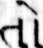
તો
